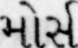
મોર્સ
